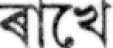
ৰাখে
